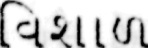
વિશાળ
